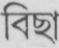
বিছা
